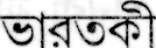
ভারতকী
